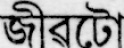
জীৱটো
